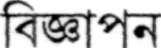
বিজ্ঞাপন
